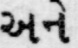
અને
